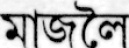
মাজলৈ
